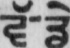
ਵੱਡੇ
